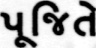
પૂજિતે
